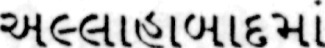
અલ્લાહાબાદમાં
